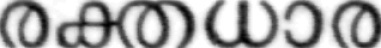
രക്തധാര
